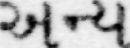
અન્ય
